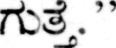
ಗುತ್ತೆ."
